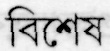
বিশেষ
